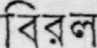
বিরল
